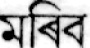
মৰিব
